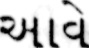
આવે
